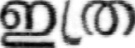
ഇത്ര
